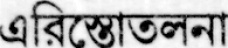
এরিস্তোতলনা
